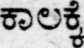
ಕಾಲಕ್ಕೆ
